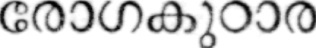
രോഗകുഠാര
